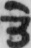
ਤੇ
